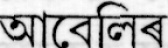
আবেলিৰ
